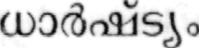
ധാര്‍ഷ്ട്യം
